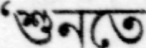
‘শুনতে
